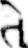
તે
